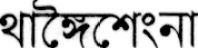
থাঙ্গৈশেংনা
